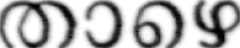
താഴെ
